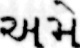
અમે
